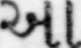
આ
